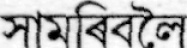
সামৰিবলৈ
